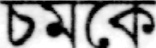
চমকে
